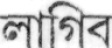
লাগিব
